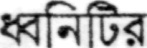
ধ্বনিটির
